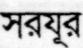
সরযূর
